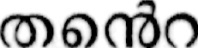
തന്റെ
